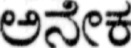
ಅನೇಕ
